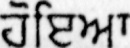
ਹੋਇਆ
